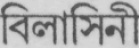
বিলাসিনী
